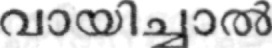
വായിച്ചാല്‍
